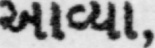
આવ્યા,
